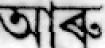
আৰু
